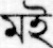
মই
